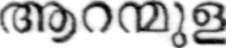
ആറന്മുള
